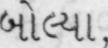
બોલ્યા,
